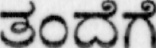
ತಂದೆಗೆ
